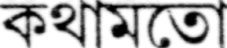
কথামতো
